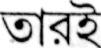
তারই
